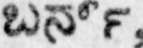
ಬರ್ನ್,
